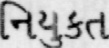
નિયુક્ત
